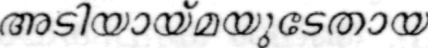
അടിയായ്മയുടേതായ
